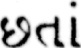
છતાં
